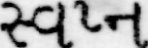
સ્વપ્ન
